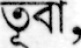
তূবা,
